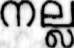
നല്ല
